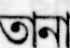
তানা
